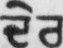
ਦੇਰ
